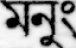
মনুং
